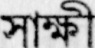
সাক্ষী
